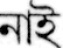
নাই
